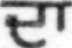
ਦਾ
